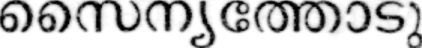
സൈന്യത്തോടു
